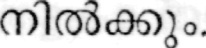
നില്‍ക്കും.
